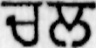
ਚਲ
